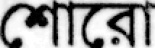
শোরো
